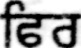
ਫਿਰ
